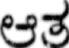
ಆತ
